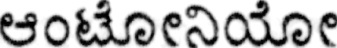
ಆಂಟೋನಿಯೋ
